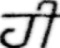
ਹੀ
